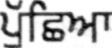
ਪੁੱਛਿਆ
